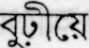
বুঢ়ীয়ে
